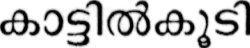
കാട്ടില്‍കൂടി
